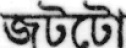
জটটো
